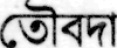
তৌবদা
